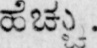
ಹೆಚ್ಚು.
